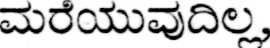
ಮರೆಯುವುದಿಲ್ಲ,
